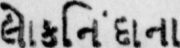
લોકનિંદાના
